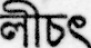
লীচৎ
